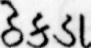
ઠેકડા
